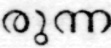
രുന്ന
